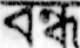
বন্ধ
